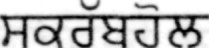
ਸਕਰੱਬਹੋਲ
